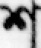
শ
